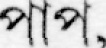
পাপ,
